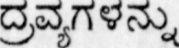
ದ್ರವ್ಯಗಳನ್ನು
